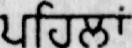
ਪਹਿਲਾਂ
